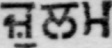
ਜ਼ੁਲਮ
